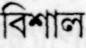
বিশাল
